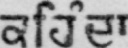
ਕਹਿੰਦਾ
